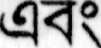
এবং
